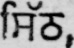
ਸਿੱਠ,
